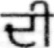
ਦੀ
